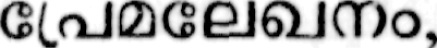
പ്രേമലേഖനം,
